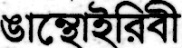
ঙান্থোইরিবী
